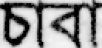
চাবা
